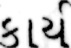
કાર્ય
